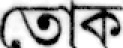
তোক
